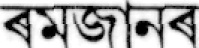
ৰমজানৰ
